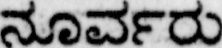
ನೂರ್ವರು
